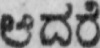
ಆದರೆ
